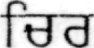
ਚਿਰ
